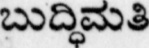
ಬುದ್ಧಿಮತಿ
